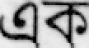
এক
